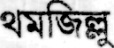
থমজিল্লু
